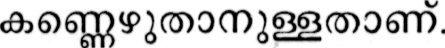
കണ്ണെഴുതാനുള്ളതാണ്.
